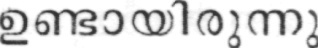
ഉണ്ടായിരുന്നു
